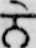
ਨੇ
